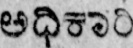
ಅಧಿಕಾರಿ
